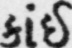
કાંઈ
